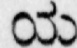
ಯ
